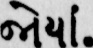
જોયાં.
